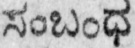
ಸಂಬಂಧ
